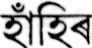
হাঁহিৰ
